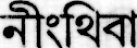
নীংথিবা
